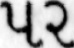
પર
